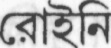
রোইনি
